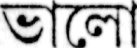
ভালো
